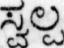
ಸ್ವಲ್ಪ
